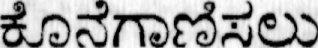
ಕೊನೆಗಾಣಿಸಲು
